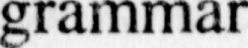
grammar
